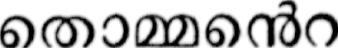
തൊമ്മന്റെ
